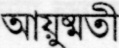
আয়ুষ্মতী
